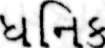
ધનિક
